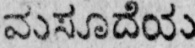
ಮಸೂದೆಯ
